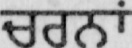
ਚਰਨਾਂ
